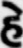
હે
